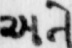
અને
